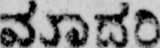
ಮಾದರಿ
